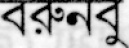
বরুনবু
